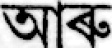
আৰু
